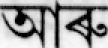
আৰু
